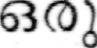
ഒരു
